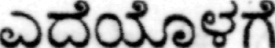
ಎದೆಯೊಳಗೆ
